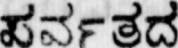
ಪರ್ವತದ
